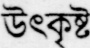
উত্কৃষ্ট
